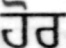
ਹੋਰ
